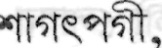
শাগৎপগী,
